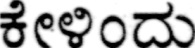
ಕೇಳಿಂದು
